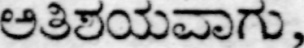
ಅತಿಶಯವಾಗು,
